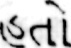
હતો
